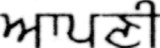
ਆਪਣੀ
